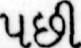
પછી
